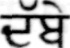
ਦੱਬੇ
